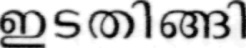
ഇടതിങ്ങി
